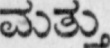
ಮತ್ತು
